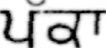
ਪੱਕਾ
